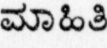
ಮಾಹಿತಿ
